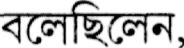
বলেছিলেন,
